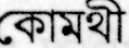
কোমথী
